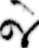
જે
